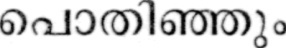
പൊതിഞ്ഞും
